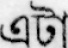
এটা
